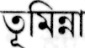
তূমিন্না
